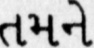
તમને
